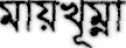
মায়খূম্না
